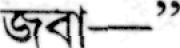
জবা-"
